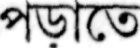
পড়াতে
